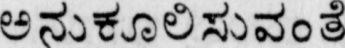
ಅನುಕೂಲಿಸುವಂತೆ
